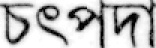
চৎপদা
